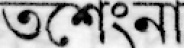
তশেংনা
